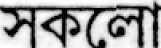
সকলো
